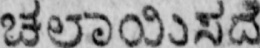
ಚಲಾಯಿಸದೆ
